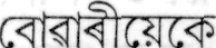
বোৱাৰীয়েকে
